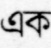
এক
